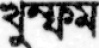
খুম্ফম
